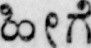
ಹೀಗೆ
